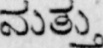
ಮತ್ತು
